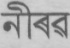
নীৰৱ
